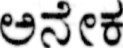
ಅನೇಕ
